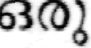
ഒരു
